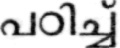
പഠിച്ച്
